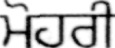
ਮੋਹਰੀ
